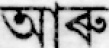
আৰু
